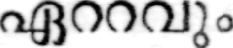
ഏററവും
